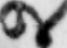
જ
